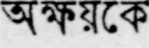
অক্ষয়কে
